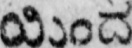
ಯಿಂದ
